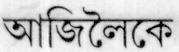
আজিলৈকে
